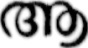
ആ
